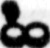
ಹಿ
